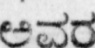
ಅವರ
